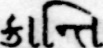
ક્રાન્તિ
